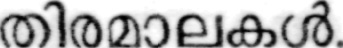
തിരമാലകള്‍.
